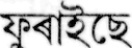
ফুৰাইছে
